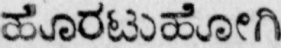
ಹೊರಟುಹೋಗಿ
